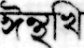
ঈন্থখি
